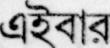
এইবার
